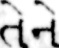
તેને
